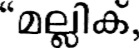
“മല്ലിക്,
